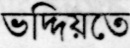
ভদ্দিয়তে
